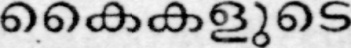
കൈകളുടെ
